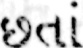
છતાં
